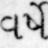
વર્ષે
